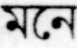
মনে
